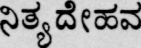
ನಿತ್ಯದೇಹವ
